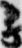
કે
